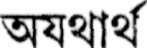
অযথার্থ
